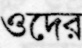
ওদের
